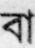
বা
